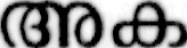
അക
